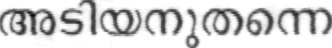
അടിയനുതന്നെ
